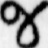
જ
